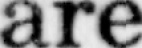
are
